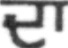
ਦਾ
